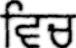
ਵਿਚ
